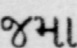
જમા
